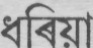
ধৰিয়া
